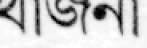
থাজনা
